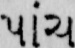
પાંય
